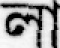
লা
